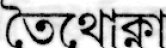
তৈথোক্না
